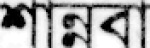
শান্নবা
